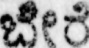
ಬೇರೆ
